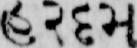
હરદમ
